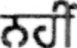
ਨਹੀਂ
